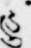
હું
